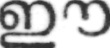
ഈ
